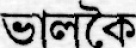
ভালকৈ
